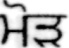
ਮੋੜ
